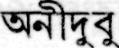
অনীদুবু
